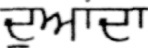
ਦੁਆਂਦਾ
